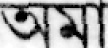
অমা
